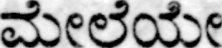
ಮೇಲೆಯೇ
